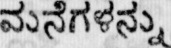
ಮನೆಗಳನ್ನು
